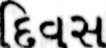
દિવસ
